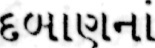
દબાણનાં
